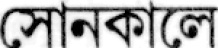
সোনকালে
